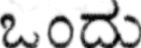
ಒಂದು
